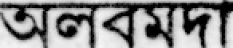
অলবমদা
